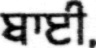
ਬਾਈ,
